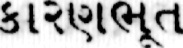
કારણભૂત
